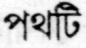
পথটি
